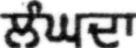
ਲੰਘਦਾ
